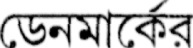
ডেনমার্কের
